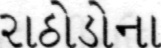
રાઠોડોના
